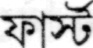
ফার্স্ট
